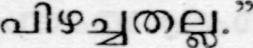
പിഴച്ചതല്ല.”
